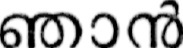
ഞാന്‍
